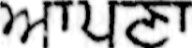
ਆਪਣਾ
